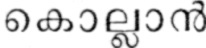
കൊല്ലാന്‍
